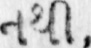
નથી,
